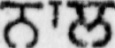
ਨਾਲ
